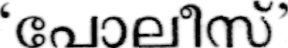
‘പോലീസ്’
